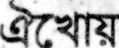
ঐখোয়
